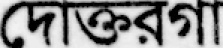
দোক্তরগা
